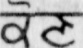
ਕੋਣ
